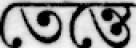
তেন্তে
